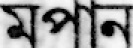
মপান
